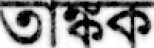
তাঙ্কক
